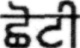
ਛੋਟੀ
